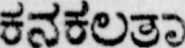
ಕನಕಲತಾ
